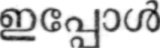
ഇപ്പോള്‍
